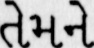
તેમને
